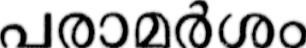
പരാമര്‍ശം
